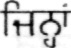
ਜਿਨ੍ਹਾਂ
